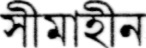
সীমাহীন
